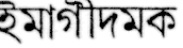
ইমাগীদমক
